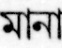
মানা
